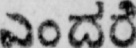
ಎಂದರೆ
